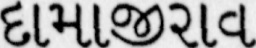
દામાજીરાવ
